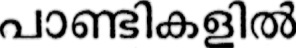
പാണ്ടികളില്‍
